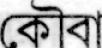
কৌবা
